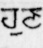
ਹੁਣ
